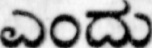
ಎಂದು
